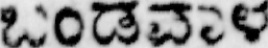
ಬಂಡವಾಳ
